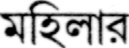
মহিলার
